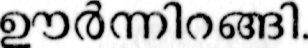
ഊര്‍ന്നിറങ്ങി.
